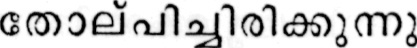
തോല്പിച്ചിരിക്കുന്നു
